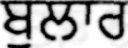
ਬੁਲਾਰ
